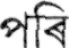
পৰি
